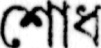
শোধ
